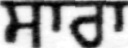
ਸਾਰਾ
